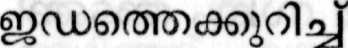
ജഡത്തെക്കുറിച്ച്
